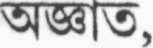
অজ্ঞাত,
